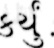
કર્યું.
